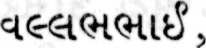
વલ્લભભાઈ,
